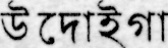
উদোইগা
